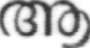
ആ
